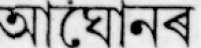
আঘোনৰ
